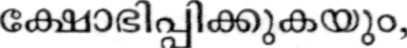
ക്ഷോഭിപ്പിക്കുകയും,
